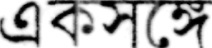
একসঙ্গে
